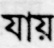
যায়
